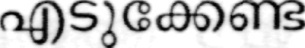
എടുക്കേണ്ട
